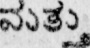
ಮತ್ತು
